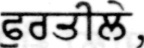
ਫੁਰਤੀਲੇ,
